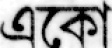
একো
